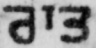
ਰਾਤ
